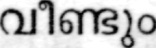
വീണ്ടും
